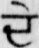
ਦੇ
